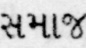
સમાજ
